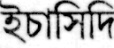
ইচাসিদি
